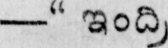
-ಇಂದ್ರಿ
